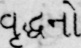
વૃદ્ધનો
